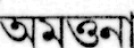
অমত্তনা
